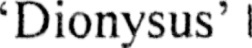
'Dionysus'।
